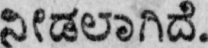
ನೀಡಲಾಗಿದೆ.
